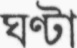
ঘণ্টা
